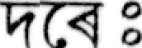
দৰেঃ
